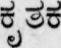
ಕೃತಕ
